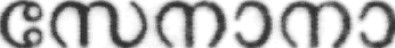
സേനാനാ
